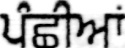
ਪੰਛੀਆਂ
